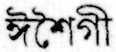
ঈশৈগী
